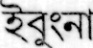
ইবুংনা
